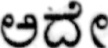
ಅದೇ
